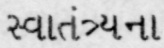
સ્વાતંત્ર્યના
